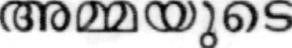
അമ്മയുടെ
